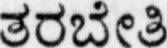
ತರಬೇತಿ
